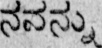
ನವನ್ನು
